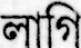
লাগি
